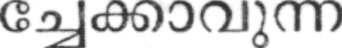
ച്ചേക്കാവുന്ന
